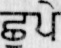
ਛੁਪੇ
